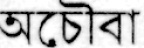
অচৌবা
